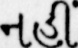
નહીં
